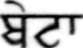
ਬੇਟਾ
